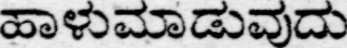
ಹಾಳುಮಾಡುವುದು
